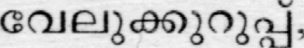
വേലുക്കുറുപ്പ്,
